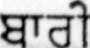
ਬਾਰੀ
